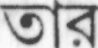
তার
